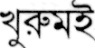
খুরুমই
